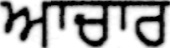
ਆਚਾਰ
